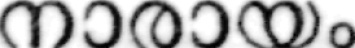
നാരായം
